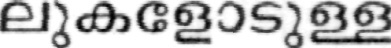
ലുകളോടുള്ള
